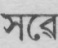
সৱে
